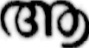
ആ
